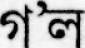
গ'ল
